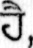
ਹੈ,
